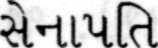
સેનાપતિ
